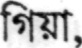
গিয়া,
